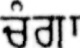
ਚੰਗਾ
